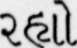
રહ્યો
